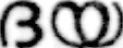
ദയ
